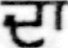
ਦਾ
